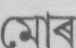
মোৰ
